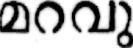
മറവു
